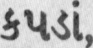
કપડાં,
